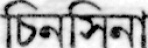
চিনসিনা
